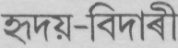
হৃদয়-বিদাৰী
